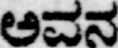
ಅವನ
